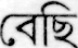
বেছি
